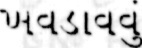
ખવડાવવું
